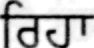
ਰਿਹਾ
